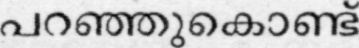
പറഞ്ഞുകൊണ്ട്
